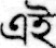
এই
